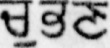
ਚੁਭਣ
